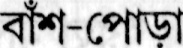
বাঁশ-পোড়া
